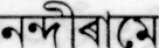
নন্দীৰামে
